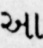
આ
